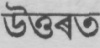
উত্তৰত
